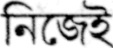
নিজেই
